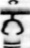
ਨੂੰ
